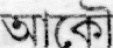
আকৌ
